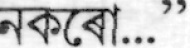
নকৰো..."
